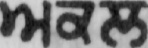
ਅਕਲ
